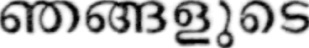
ഞങ്ങളുടെ
